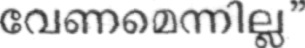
വേണമെന്നില്ല”
